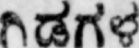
ಗಿಡಗಳ
